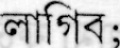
লাগিব;
